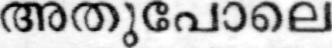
അതുപോലെ
